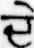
ਦੇ
